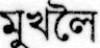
মুখলৈ
